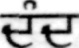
ਦੰਦ
